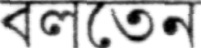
বলতেন
